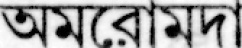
অমরোমদা
